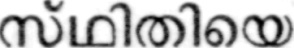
സ്ഥിതിയെ
